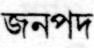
জনপদ
